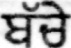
ਬੱਚੇ
